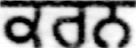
ਕਰਨ
